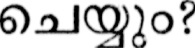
ചെയ്യും?
